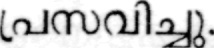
പ്രസവിച്ചു.
